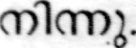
നിന്നു.
